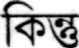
কিন্তু
